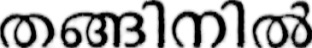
തങ്ങിനില്‍
